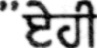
''ਏਹੀ
